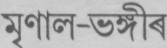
মৃণাল-ভঙ্গীৰ
